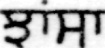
ਝਾਂਸਾ
